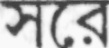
সরে
